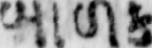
બાળક
